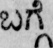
ಬಗ್ಗೆ
